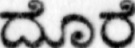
ದೊರೆ
